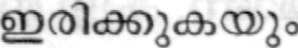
ഇരിക്കുകയും
